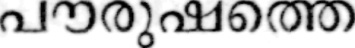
പൌരുഷത്തെ
